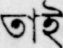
তাই
